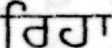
ਰਿਹਾ
